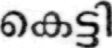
കെട്ടി
